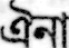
ঐনা
